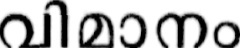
വിമാനം
